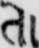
તો
